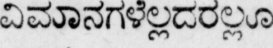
ವಿಮಾನಗಳೆಲ್ಲದರಲ್ಲೂ
